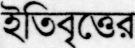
ইতিবৃত্তের
